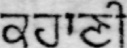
ਕਹਾਣੀ
